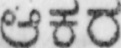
ಆಕರ
